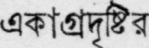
একাগ্রদৃষ্টির
